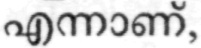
എന്നാണ്,
